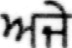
ਅਜੇ
